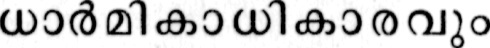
ധാര്‍മികാധികാരവും
